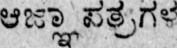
ಅಜ್ಞಾಪತ್ರಗಳ
